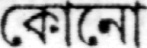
কোনো
